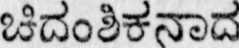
ಚಿದಂಶಿಕನಾದ
